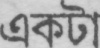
একটা
